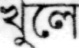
খুলে
